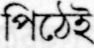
পিঠেই
